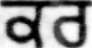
ਕਰ
